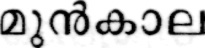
മുന്‍കാല
